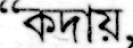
বীসকুটতো
